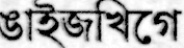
ঙাইজখিগে
